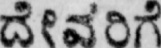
ದೇವರಿಗೆ
